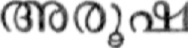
അരൂഷ
